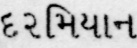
દરમિયાન
